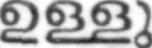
ഉള്ളു
